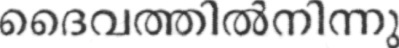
ദൈവത്തില്‍നിന്നു
